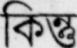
কিন্তু
